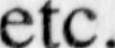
etc.
